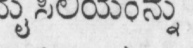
ಮೃಸಿಲಯಂನ್ನು
